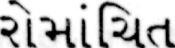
રોમાંચિત
